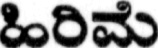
ಹಿರಿಮೆ
